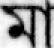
মা
